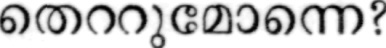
തെററുമോന്നെ?
